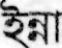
ইন্না
